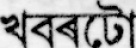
খবৰটো
